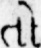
તો
